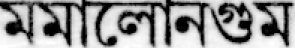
মমালোনগুম
